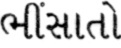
ભીંસાતો
